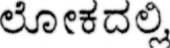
ಲೋಕದಲ್ಲಿ
